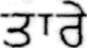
ਤਾਰੇ
